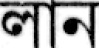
লান
